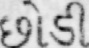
છોડી
